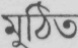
মুঠিত
